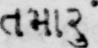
તમારું
